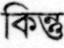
কিন্তু
